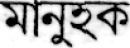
মানুহক
